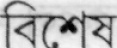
বিশেষ
